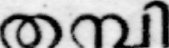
തമ്പി
